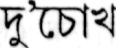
দু’চোখ
